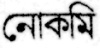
নোকমি
